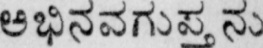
ಅಭಿನವಗುಪ್ತನು
